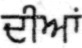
ਦੀਆਂ
